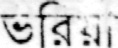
ভরিয়া
